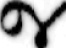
જ
